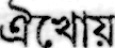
ঐখোয়
